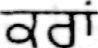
ਕਰਾਂ
